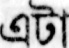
এটা
